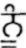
ਨੂੰ
